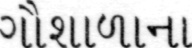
ગૌશાળાના
